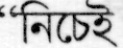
"নিচেই
